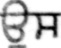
ਉਸ
